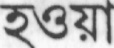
হওয়া
